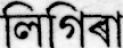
লিগিৰা
